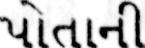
પોતાની
